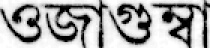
ওজাগুম্বা
